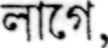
লাগে,
